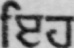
ਇਹ
